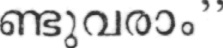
ണ്ടുവരാം"
